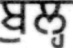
ਬੁਲ੍ਹ
